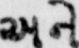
અને
